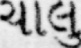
ચાલુ
